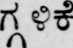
ಗ್ಗಳಿಕೆ
